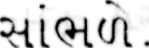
સાંભળે.
